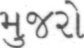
મુજરો
